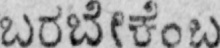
ಬರಬೇಕೆಂಬ
